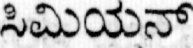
ಸಿಮಿಯನ್
